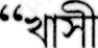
“খাসী
